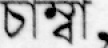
চাম্বা,
